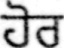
ਹੋਰ
